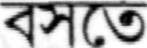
বসতে
